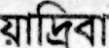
য়াদ্রিবা
